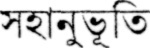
সহানুভূতি
